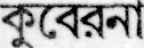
কুবেরনা
